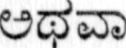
ಅಥವಾ
